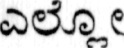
ಎಲ್ಲೋ
